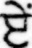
ਏਂ
